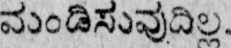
ಮಂಡಿಸುವುದಿಲ್ಲ.
